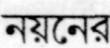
নয়নের
